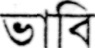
ভাবি
